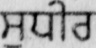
ਸੁਧੀਰ
